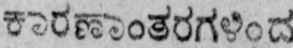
ಕಾರಣಾಂತರಗಳಿಂದ
